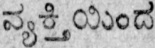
ವ್ಯಕ್ತಿಯಿಂದ
